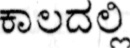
ಕಾಲದಲ್ಲಿ
